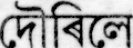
দৌৰিলে
